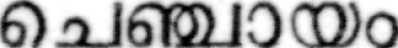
ചെഞ്ചായം
